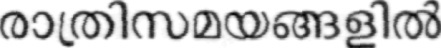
രാത്രിസമയങ്ങളില്‍
